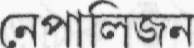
নেপালিজন
